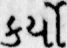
કર્યો
